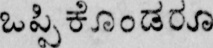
ಒಪ್ಪಿಕೊಂಡರೂ
